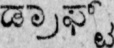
ಡ್ರಾಫ್ಟ್
